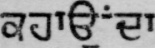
ਕਹਾਉਂਦਾ
